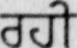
ਰਹੀ
